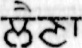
ਲੈਣਾ
